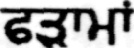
ਫੜਾਮਾਂ
